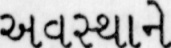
અવસ્થાને
